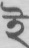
ই
